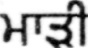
ਮਾੜੀ
